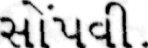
સોંપવી.
